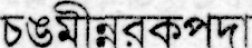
চঙমীন্নরকপদা
